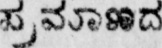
ಪ್ರಮಾಣದ
